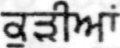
ਕੁੜੀਆਂ
